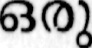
ഒരു
